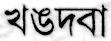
খঙদবা
